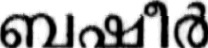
ബഷീര്‍
